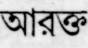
আরক্ত
